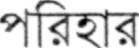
পরিহার
